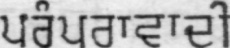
ਪਰੰਪਰਾਵਾਦੀ
